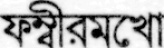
ফম্বীরমখো
